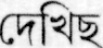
দেখিছ
